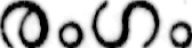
രംഗം
